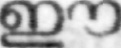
ഈ
